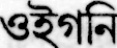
ওইগনি
